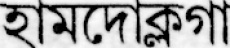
হামদোক্লগা
